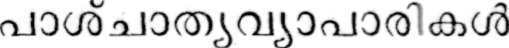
പാശ്ചാത്യവ്യാപാരികള്‍
